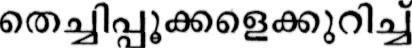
തെച്ചിപ്പൂക്കളെക്കുറിച്ച്
